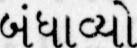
બંધાવ્યો
